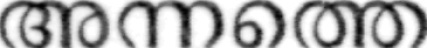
അന്നത്തെ
